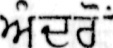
ਅੰਦਰੋਂ
